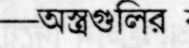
–অস্ত্রগুলির
